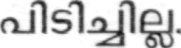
പിടിച്ചില്ല.
